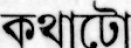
কথাটো
